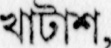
খাটাশ,
